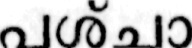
പശ്ചാ
